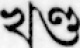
খণ্ড
